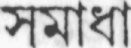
সমাধা
